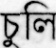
চুলি
